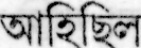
আহিছিল
